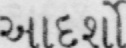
આદર્શો
